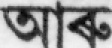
আৰু
